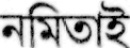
নমিতাই
